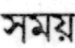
সময়
